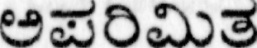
ಅಪರಿಮಿತ
